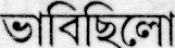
ভাবিছিলো
